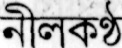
নীলকণ্ঠ
